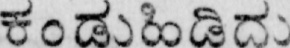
ಕಂಡುಹಿಡಿದು
